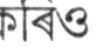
কৰিও
